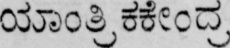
ಯಾಂತ್ರಿಕಕೇಂದ್ರ
